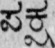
ಪಕ್ಷ
